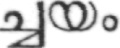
ച്ചയം
